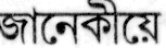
জানেকীয়ে
